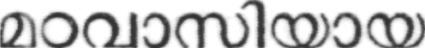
മഠവാസിയായ
